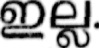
ഇല്ല.
